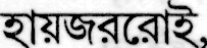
হায়জররোই,
